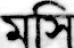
মসি
